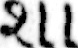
શા
